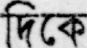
দিকে
